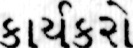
કાર્યકરો
